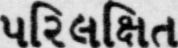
પરિલક્ષિત
